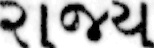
રાજ્ય
